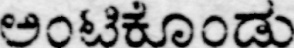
ಅಂಟಿಕೊಂಡು
